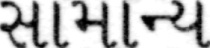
સામાન્ય
